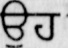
ਉਹ
